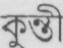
কুন্তী
